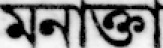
মনাক্তা
